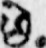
છે.
